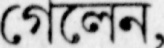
গেলেন,
